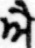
ਐ
